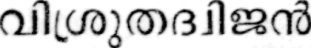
വിശ്രുതദ്വിജന്‍
